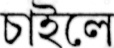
চাইলে
